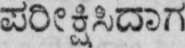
ಪರೀಕ್ಷಿಸಿದಾಗ
